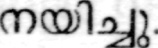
നയിച്ചു.
